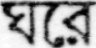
ঘরে
